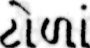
ટોળાં
